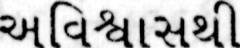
અવિશ્વાસથી
